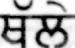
ਥੱਲੇ
